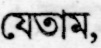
যেতাম,
